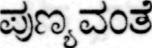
ಪುಣ್ಯವಂತೆ
